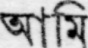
আমি
